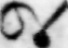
જ
